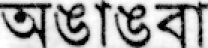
অঙাঙবা
